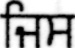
ਜਿਸ
